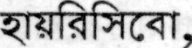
হায়রিসিবো,
